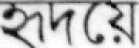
হৃদয়ে
